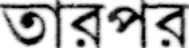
তারপর
